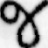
જ
